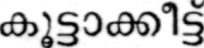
കൂട്ടാക്കീട്ട്
